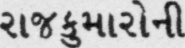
રાજકુમારોની
